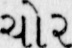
ચોર
